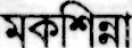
মকশিন্না
